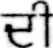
ਦੀ
